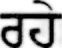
ਰਹੇ
